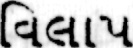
વિલાપ
